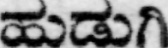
ಹುಡುಗಿ
